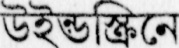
উইন্ডস্ক্রিনে
